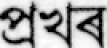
প্রখৰ
